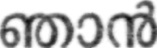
ഞാന്‍
